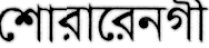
শোরারেনগী
